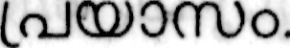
പ്രയാസം.
